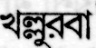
খল্লুরবা
